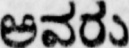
ಅವರು
